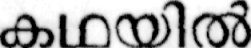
കഥയില്‍
